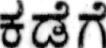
ಕಡೆಗೆ
